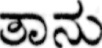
ತಾನು
